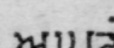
ਆਪਣੇ
